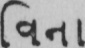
વિના
